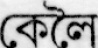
কেলৈ
